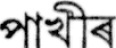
পাখীৰ
